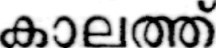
കാലത്ത്
